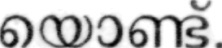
യൊണ്ട്.
